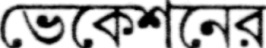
ভেকেশনের
